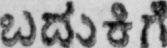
ಬದುಕಿಗೆ
